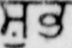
ਸ਼ੁਭ
